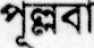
পূল্লবা
